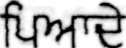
ਪਿਆਦੇ
